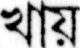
খায়
